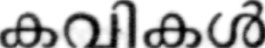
കവികള്‍
